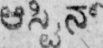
ಆಸ್ಟಿನ್
